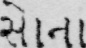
સોના
